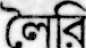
লৈরি
